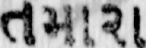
તમારા
